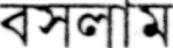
বসলাম
